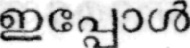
ഇപ്പോള്‍
